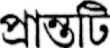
প্রান্তটি
